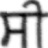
ਸੀ
